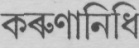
কৰুণানিধি
